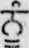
ਨੂੰ
